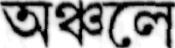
অঞ্চলে
